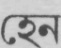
হেন
